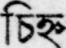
চিহ্ন
